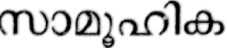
സാമൂഹിക
